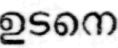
ഉടനെ
